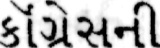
કૉંગ્રેસની
